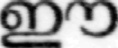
ഈ
